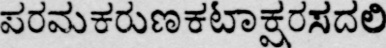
ಪರಮಕರುಣಕಟಾಕ್ಷರಸದಲಿ
